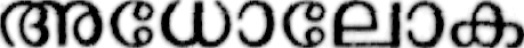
അധോലോക
